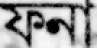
ফনা
